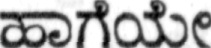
ಹಾಗೆಯೇ
